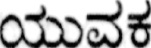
ಯುವಕ
